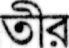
তীর
